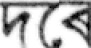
দৰে
